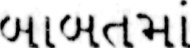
બાબતમાં
